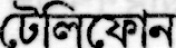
টেলিফোন
